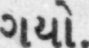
ગયો.
